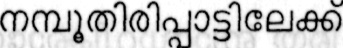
നമ്പൂതിരിപ്പാട്ടിലേക്ക്
